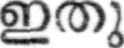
ഇതു
